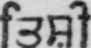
ਤਿਸ਼ੀ
